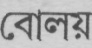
বোলয়
